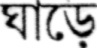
ঘাড়ে
